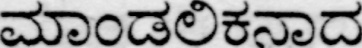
ಮಾಂಡಲಿಕನಾದ
